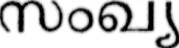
സംഖ്യ
